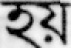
হয়
